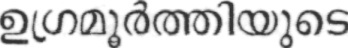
ഉഗ്രമൂര്‍ത്തിയുടെ
